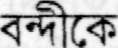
বন্দীকে
